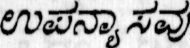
ಉಪನ್ಯಾಸವು
